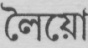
লৈয়ো
